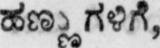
ಹಣ್ಣುಗಳಿಗೆ,
